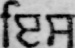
ਇਸ
